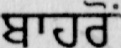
ਬਾਹਰੋਂ
